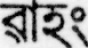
ৱাহং
